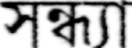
সন্ধ্যা
